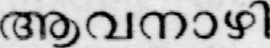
ആവനാഴി
